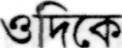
ওদিকে
